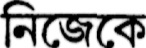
নিজেকে
